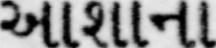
આશાના
